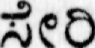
ಸೇರಿ
